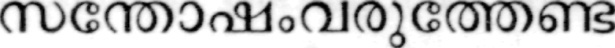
സന്തോഷംവരുത്തേണ്ട
